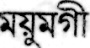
ময়ুমগী
